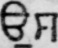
ਉਸ
